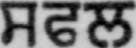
ਸਫਲ
